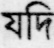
যদি
